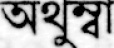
অথুম্বা
